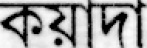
কয়াদা
